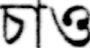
চাও
